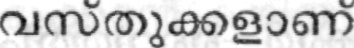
വസ്തുക്കളാണ്
